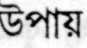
উপায়
